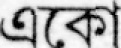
একো
